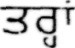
ਤਰ੍ਹਾਂ
